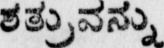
ಶತ್ರುವನ್ನು
